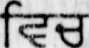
ਵਿਚ
